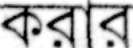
করার
